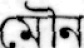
মৌন
